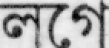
লগে
